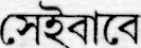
সেইবাবে
